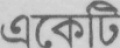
একেটি
